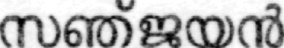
സഞ്ജയന്‍
